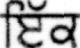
ਇੱਕ
